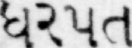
ધરપત
